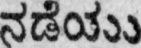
ನಡೆಯು
